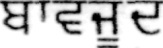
ਬਾਵਜੂਦ
